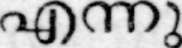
എന്നു
